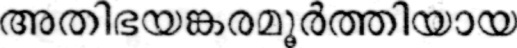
അതിഭയങ്കരമൂര്‍ത്തിയായ
